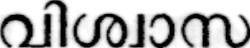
വിശ്വാസ
